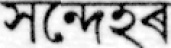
সন্দেহৰ
